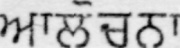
ਆਲੋਚਨਾ
